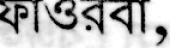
ফাওরবা,
